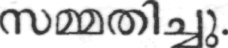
സമ്മതിച്ചു.
